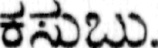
ಕಸುಬು.
